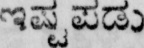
ಇಷ್ಟಪಡು
